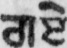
ਗਏ
